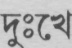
দুঃখে
